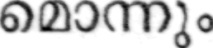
മൊന്നും
